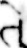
તે
